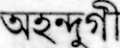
অহন্দুগী
